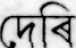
দেৰি
